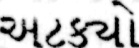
અટક્યો
